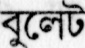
বুলেট
